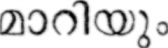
മാറിയും
